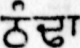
ਠੰਢਾ
